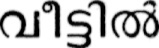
വീട്ടില്‍
